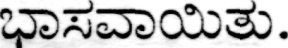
ಭಾಸವಾಯಿತು.
